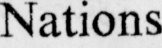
Nations
